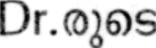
Dr.രുടെ
